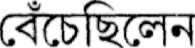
বেঁচেছিলেন
